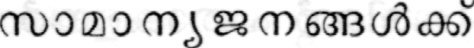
സാമാന്യജനങ്ങള്‍ക്ക്
